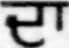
ਦਾ
